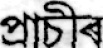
প্রাচীৰ
